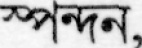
স্পন্দন,
